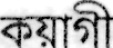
কয়াগী
